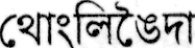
থোংলিঙৈদা
